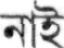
নাই
